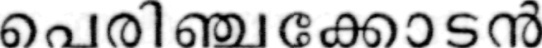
പെരിഞ്ചക്കോടന്‍
